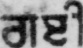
ਗਈ
